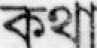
কথা
